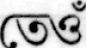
তেওঁ
